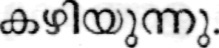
കഴിയുന്നു.
